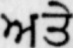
ਅਤੇ
